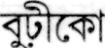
বুঢ়ীকো
